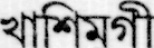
খাশিমগী
